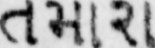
તમારા
